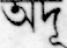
অদূ
